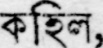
কহিল,
